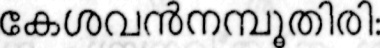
കേശവന്‍നമ്പൂതിരി:
